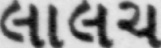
લાલચ
